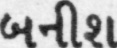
બનીશ
